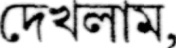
দেখলাম,
